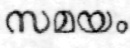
സമയം
